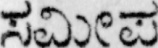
ಸಮೀಪ
